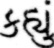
કહ્યું
